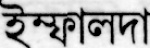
ইম্ফালদা
